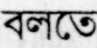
বলতে
